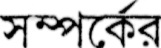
সম্পর্কের
